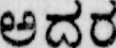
ಅದರ
